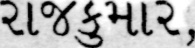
રાજકુમાર,
